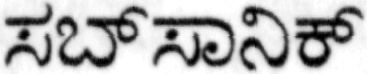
ಸಬ್‌ಸಾನಿಕ್
